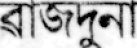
ৱাজদুনা
